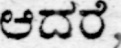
ಆದರೆ,
